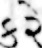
કરે
